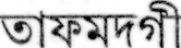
তাফমদগী
